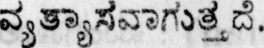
ವ್ಯತ್ಯಾಸವಾಗುತ್ತದೆ.
